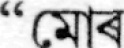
"মোৰ
